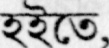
হইতে,
